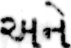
અને
